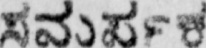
ಸಮರ್ಪಕ
